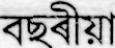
বছৰীয়া
